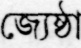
জ্যেষ্ঠা
